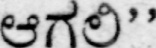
ಆಗಲಿ"
